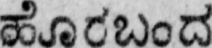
ಹೊರಬಂದ
